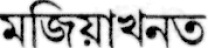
মজিয়াখনত
